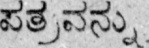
ಪತ್ರವನ್ನು
